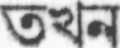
তখন
